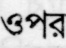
ওপর
